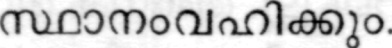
സ്ഥാനംവഹിക്കും.
